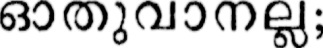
ഓതുവാനല്ല;
